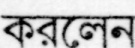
করলেন
